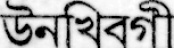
উনখিবগী
